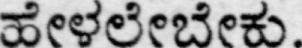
ಹೇಳಲೇಬೇಕು.
